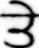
ਤੇ
